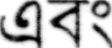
এবং
